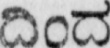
ದಿಂದ
